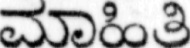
ಮಾಹಿತಿ
